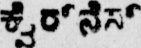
ಕ್ವೆರ್ನೆಸ್
